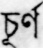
চূর্ণ
